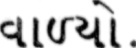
વાળ્યો.
